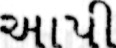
આપી
